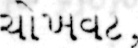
ચોખવટ,
